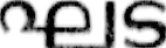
ഘട
